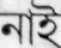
নাই
